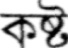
কষ্ট
